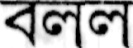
বলল
